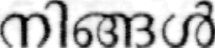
നിങ്ങള്‍
